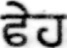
ਫੇਹ
